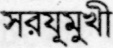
সরযূমুখী
